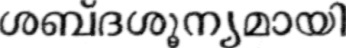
ശബ്ദശൂന്യമായി
